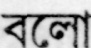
বলো
